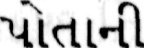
પોતાની
